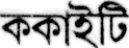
ককাইটি
